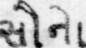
સૌનો
